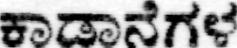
ಕಾಡಾನೆಗಳ
